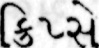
ક્રિપ્સે
